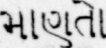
માણતો
